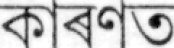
কাৰণত
